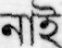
নাই
